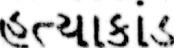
હત્યાકાંડ
